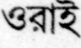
ওরাই
